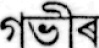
গভীৰ
